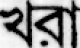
খরা
